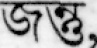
জন্তু,
